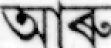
আৰু
